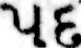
પદ
